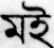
মই
